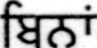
ਬਿਨਾਂ
